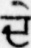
ਦੇ
